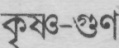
কৃষ্ণ-গুণ
